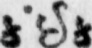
કંઈક
